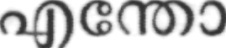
എന്തോ
